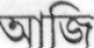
আজি
